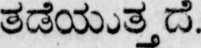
ತಡೆಯುತ್ತದೆ.
